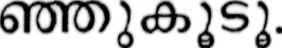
ഞ്ഞുകൂടൂ.
